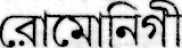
রোমোনিগী
